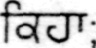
ਕਿਹਾ;
